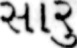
સારુ
